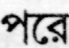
পরে
